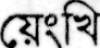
য়েংখি
